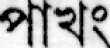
পাখং
